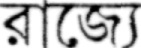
রাজ্যে
